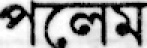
পলেম
